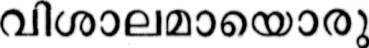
വിശാലമായൊരു
